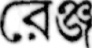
রেঞ্জ
